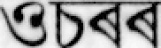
ওচৰৰ
